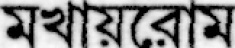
মখায়রোম
